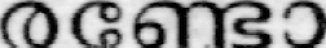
രണ്ടോ
